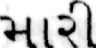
મારી
